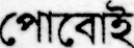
পোবোই
